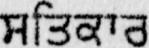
ਸਤਿਕਾਰ
